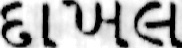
દાખલ
